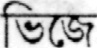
ভিজে
